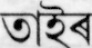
তাইৰ
